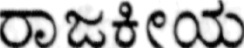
ರಾಜಕೀಯ
